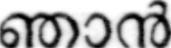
ഞാന്‍
